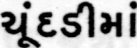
ચૂંદડીમાં
